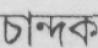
চান্দক
